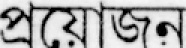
প্রয়োজন
